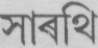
সাৰথি
